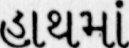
હાથમાં
